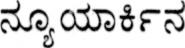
ನ್ಯೂಯಾರ್ಕಿನ
